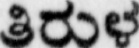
ತಿರುಳ
